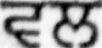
ਵਲ
